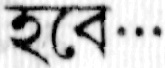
হবে....
